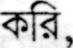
করি,
